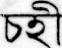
চহী
